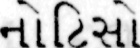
નોટિસો
